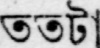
ততটা
